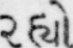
રહ્યો
